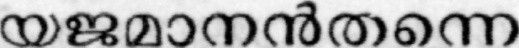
യജമാനന്‍തന്നെ
